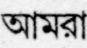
আমরা
